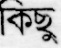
কিছু
